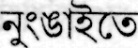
নুংঙাইতে
